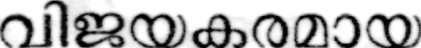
വിജയകരമായ
